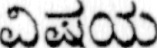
ವಿಷಯ
